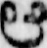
ಆ
